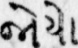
જોયો
